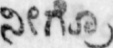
ನೀಗ್ರೊ
